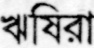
ঋষিরা
